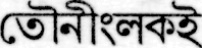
তৌনীংলকই
